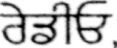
ਰੇਡੀਓ,
